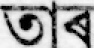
তাৰ
